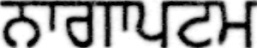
ਨਾਗਾਪਟਮ
